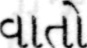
વાતો
